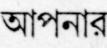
আপনার
